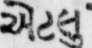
એટલું
